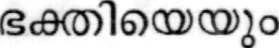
ഭക്തിയെയും
